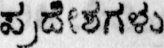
ಪ್ರದೇಶಗಳು
